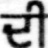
ਦੀ
